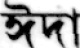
ঈদা
